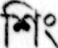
শিং
